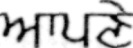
ਆਪਣੇ
